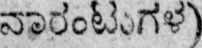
ವಾರಂಟುಗಳ)
